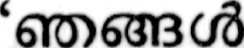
‘ഞങ്ങള്‍
